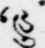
'હું
